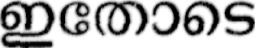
ഇതോടെ
